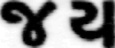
જય
